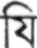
যি
